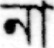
না
